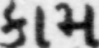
કામ
